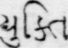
યુક્તિ
